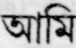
আমি
